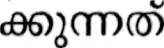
ക്കുന്നത്
